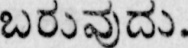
ಬರುವುದು.
